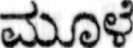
ಮೂಳೆ
